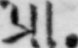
પ્રા.
